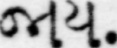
જાય.
